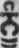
ਨੂੰ
